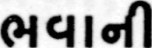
ભવાની
